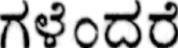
ಗಳೆಂದರೆ
